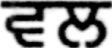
ਵਲ
